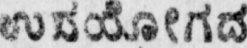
ಉಪಯೋಗದ
